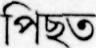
পিছত
